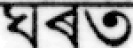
ঘৰত
